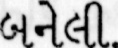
બનેલી.
